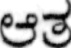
ಆತ
